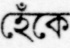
হেঁকে
